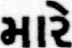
મારે
